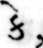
કે,
